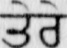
ਤੇਰੇ
